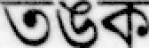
তঙক
